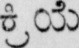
ಕ್ರಿಯೆ
